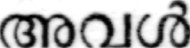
അവള്‍
